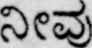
ನೀವು
